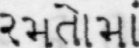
રમતોમાં
